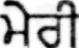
ਮੇਰੀ
